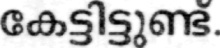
കേട്ടിട്ടുണ്ട്.
